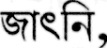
জাৎনি,
